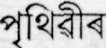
পৃথিৱীৰ
